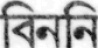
বিননি
